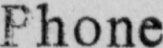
Phone
